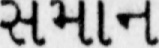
સમાન
